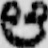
ಆ
